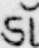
ડૉ.
